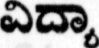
ವಿದ್ಯಾ
